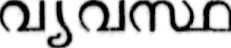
വ്യവസ്ഥ
